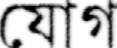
যোগ
